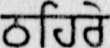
ਠਹਿਰੇ
